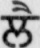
ਲੈ
